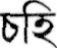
চহি
